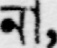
না,
